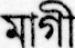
মাগী
